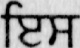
ਇਸ
